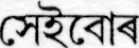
সেইবোৰ
